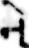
ને
